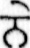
ਨੇ
